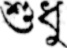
শুধু
